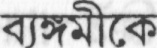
ব্যঙ্গমীকে
